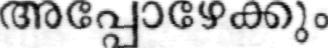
അപ്പോഴേക്കും
